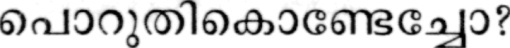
പൊറുതികൊണ്ടേച്ചോ?
